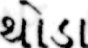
થોડા
